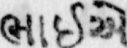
ભાઈએ
